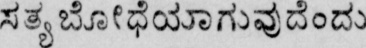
ಸತ್ಯಬೋಧೆಯಾಗುವುದೆಂದು
